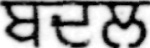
ਬਦਲ
